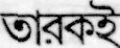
তারকই
